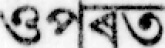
ওপৰত
